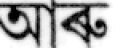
আৰু
